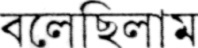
বলেছিলাম
